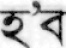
হ'ব
